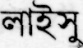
লাইসু
